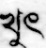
খুৱ
